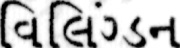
વિલિંગ્ડન
